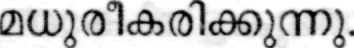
മധുരീകരിക്കുന്നു.
